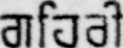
ਗਹਿਰੀ
